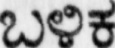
ಬಳಿಕ
